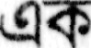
এক
